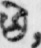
છે,
